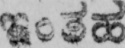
ಇಂತಹ
